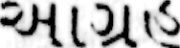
આગ્રહ
